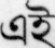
এই
